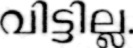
വിട്ടില്ല.
